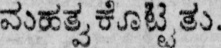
ಮಹತ್ವಕೊಟ್ಟಿತು.
